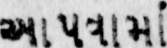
આપવામાં
